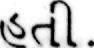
હતી.
